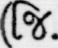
(જિ.
